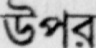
উপর
